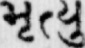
મૃત્યુ
